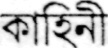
কাহিনী
